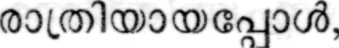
രാത്രിയായപ്പോള്‍,
